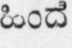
ಹಿಂದೆ
